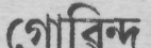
গোৱিন্দ
